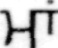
ਮਾਂ
